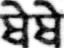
ਬੇਬੇ
